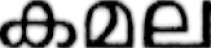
കമല
